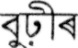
বুঢ়ীৰ
